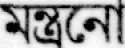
মন্ত্রনো
